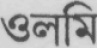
ওলমি
